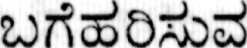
ಬಗೆಹರಿಸುವ
